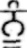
ਨੂੰ
